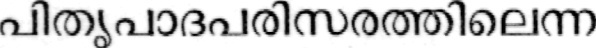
പിതൃപാദപരിസരത്തിലെന്ന
